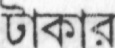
টাকার
